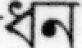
ধন
